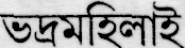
ভদ্রমহিলাই
